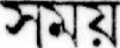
সময়
